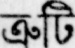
ত্রুটি
